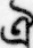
ঐ
